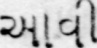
આવી
